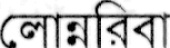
লোন্নরিবা
